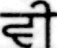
ਵੀ
